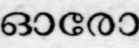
ഓരോ
